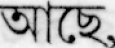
আছে,
